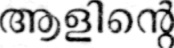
ആളിന്റെ
